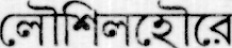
লৌশিলহৌরে
